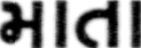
માતા
